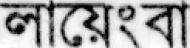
লায়েংবা
